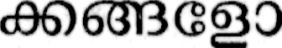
ക്കങ്ങളോ
